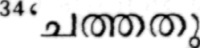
34'ചത്തതു
